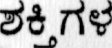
ಶಕ್ತಿಗಳ
